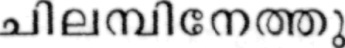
ചിലമ്പിനേത്തു
